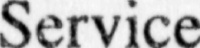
Service
